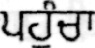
ਪਹੁੰਚਾ
